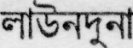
লাউনদুনা
